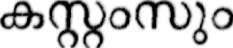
കസ്റ്റംസും
